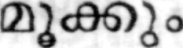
മൂക്കും
